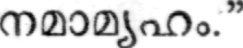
നമാമ്യഹം.”
